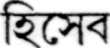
হিসেব
